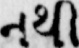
નથી
